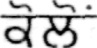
ਕੋਲੋਂ
